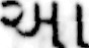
આ
